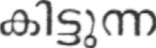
കിട്ടുന്ന
